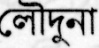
লৌদুনা
